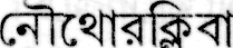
নৌথোরক্লিবা
